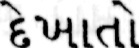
દેખાતો
